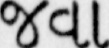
જવા
